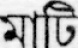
মাটি
